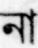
না
